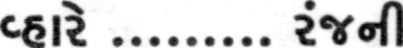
વ્હારે.........રંજની
